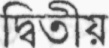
দ্বিতীয়
